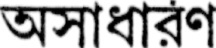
অসাধারণ
